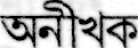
অনীখক
